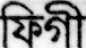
ফিগী
